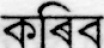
কৰিব
